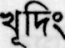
খূদিং
